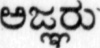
ಅಜ್ಞರು
